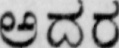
ಅದರ
